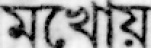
মখোয়
